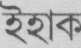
ইহাক
